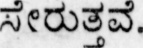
ಸೇರುತ್ತವೆ.
